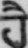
ਹੈ
